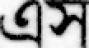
এস
